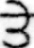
ਤੇ
